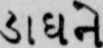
ડાઘને
